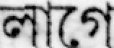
লাগে
